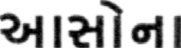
આસોના
